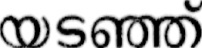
യടഞ്ഞ്
